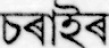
চৰাইৰ
